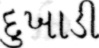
દુખાડી
